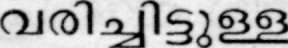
വരിച്ചിട്ടുള്ള
